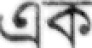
এক
